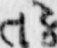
તકે
